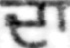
ਦਾ
